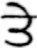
ਤੇ
